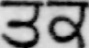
ਤਕ
